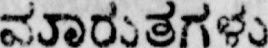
ಮಾರುತಗಳು
